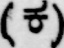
(ಕ)
